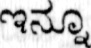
ಇನ್ನೂ
